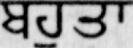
ਬਹੁਤਾ
